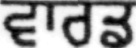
ਵਾਰਡ
